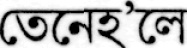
তেনেহ'লে
